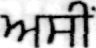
ਅਸੀ
